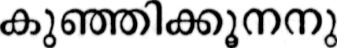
കുഞ്ഞിക്കൂനനു
